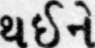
થઈને
